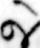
જે
